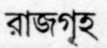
রাজগৃহ
